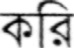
করি
